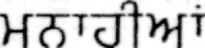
ਮਨਾਹੀਆਂ
